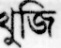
খুজি
